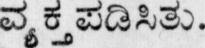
ವ್ಯಕ್ತಪಡಿಸಿತು.
